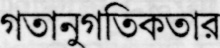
গতানুগতিকতার
